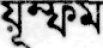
য়ূম্ফম
